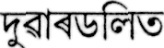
দুৱাৰডলিত
